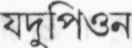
যদুপিওন
